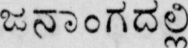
ಜನಾಂಗದಲ್ಲಿ
